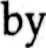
by
